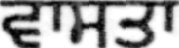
ਵਾਸਤਾ
